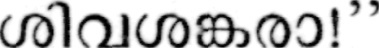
ശിവശങ്കരാ!"
